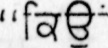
''ਕਿਉਂ
